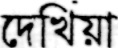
দেখিয়া
